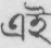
এই
